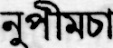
নুপীমচা
